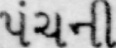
પંચની
